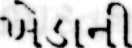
ખેડાની
